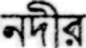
নদীর
